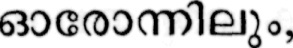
ഓരോന്നിലും,
